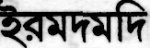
ইরমদমদি
